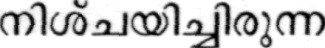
നിശ്ചയിച്ചിരുന്ന
